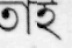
তাই
